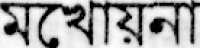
মখোয়না
